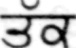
ਤੱਕ
